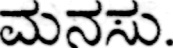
ಮನಸು.
